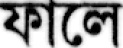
ফালে
